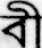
বী
